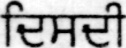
ਦਿਸਦੀ
